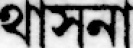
থাসনা
